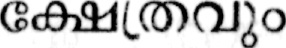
ക്ഷേത്രവും
